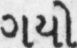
ગયો
